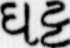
ઘટ્ટ
